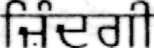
ਜ਼ਿੰਦਗੀ
